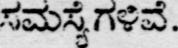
ಸಮಸ್ಯೆಗಳಿವೆ.
